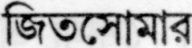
জিতসোমার
